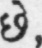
છે,
